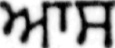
ਆਸ
